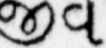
જીવ
